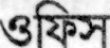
ওফিস
